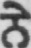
ਨੇ
